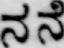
ನನೆ
